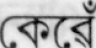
কেৱেঁ
